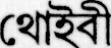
থোইবী
